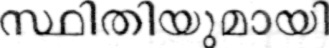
സ്ഥിതിയുമായി
